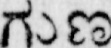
ಗುಣ
